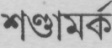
শণ্ডামৰ্ক
